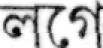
লগে
